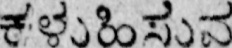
ಕಳುಹಿಸುವ
